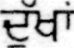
ਦੁੱਖਾਂ
